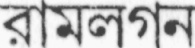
রামলগন
